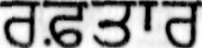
ਰਫ਼ਤਾਰ
